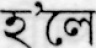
হ'লে
